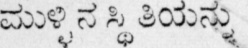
ಮುಳ್ಳಿನಸ್ಥಿತಿಯನ್ನು
